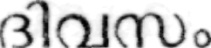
ദിവസം
